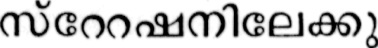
സ്റേറഷനിലേക്കു
